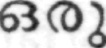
ഒരു
